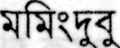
মমিংদুবু
